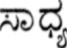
ಸಾಧ್ಯ
